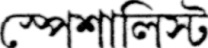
স্পেশালিস্ট
